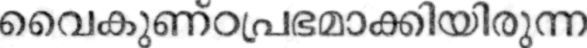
വൈകുണ്ഠപ്രഭമാക്കിയിരുന്ന
